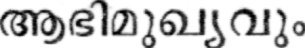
ആഭിമുഖ്യവും
